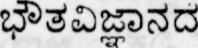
ಭೌತವಿಜ್ಞಾನದ
